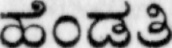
ಹೆಂಡತಿ
